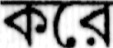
করে
